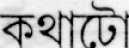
কথাটো
